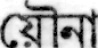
য়ৌনা
